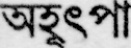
অহূৎপা
